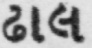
ઢાલ
